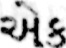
એક
